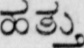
ಹತ್ತು
